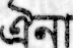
ঐনা
